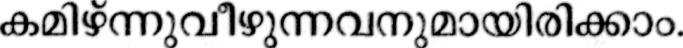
കമിഴ്ന്നുവീഴുന്നവനുമായിരിക്കാം.
